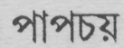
পাপচয়
